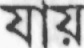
যায়
